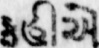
કહીએ
